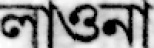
লাওনা
